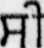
ਸੀ
